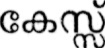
കേസ്സ്
